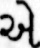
એ
